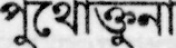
পুথোক্তুনা
